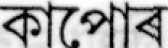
কাপোৰ
